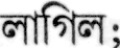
লাগিল;
